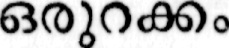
ഒരുറക്കം
